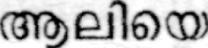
ആലിയെ
